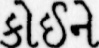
કોઈને
